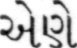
એણે
